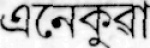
এনেকুৱা
